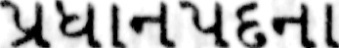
પ્રધાનપદના
